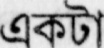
একটা
